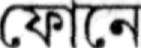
ফোনে
